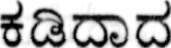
ಕಡಿದಾದ
